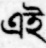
এই
